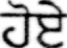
ਹੋਏ
